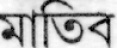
মাতিব
